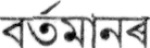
বর্তমানৰ
